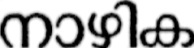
നാഴിക
